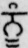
ਨੂੰ
